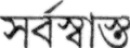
সর্বস্বাস্ত
